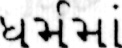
ધર્મમાં
